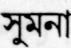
সুমনা
